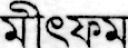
মীৎফম
